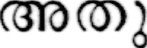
അതു
